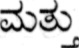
ಮತ್ತು
